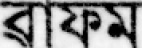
ৱাফম
